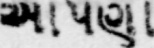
આપણા
